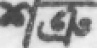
শত্ৰু
